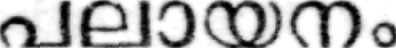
പലായനം
